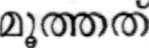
മൂത്തത്
